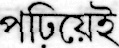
পঢ়িয়েই
